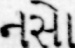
નસો
